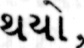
થયો,
